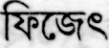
ফিজেৎ
